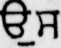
ਉਸ
